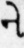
ને
